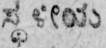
ಸ್ಥಳೀಯ
